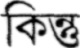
কিন্তু
